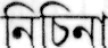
নিচিনা
